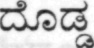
ದೊಡ್ಡ
